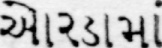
ઓરડામાં
